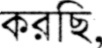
করছি,
